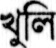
খুলি
